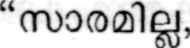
“സാരമില്ല,
